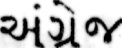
અંગ્રેજ
